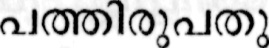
പത്തിരുപതു
